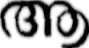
ആ
